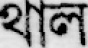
থাল
